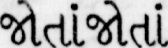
જોતાંજોતાં
